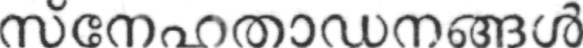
സ്നേഹതാഡനങ്ങള്‍
